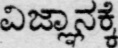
ವಿಜ್ಞಾನಕ್ಕೆ
